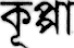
কূপ্পা
